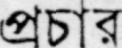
প্রচার
